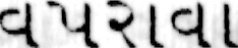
વપરાવા
